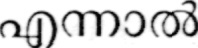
എന്നാല്‍
